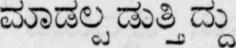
ಮಾಡಲ್ಪಡುತ್ತಿದ್ದು
